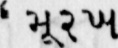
'મૂરખ
